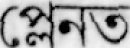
প্লেনত
